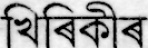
খিৰিকীৰ
